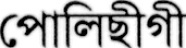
পোলিছীগী
